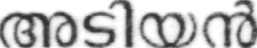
അടിയന്‍
